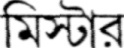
মিস্টার
